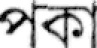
পকা
